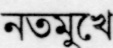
নতমুখে
